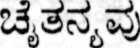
ಚೈತನ್ಯವು
